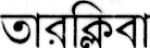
তারক্লিবা
